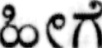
ಹೀಗೆ
